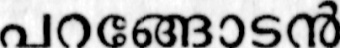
പറങ്ങോടന്‍
